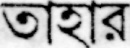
তাহার
